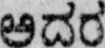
ಅದರ
